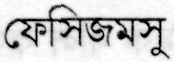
ফেসিজমসু
